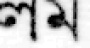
লম
